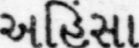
અહિંસા
